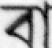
বা
